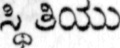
ಸ್ಥಿತಿಯು
